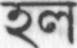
হল
